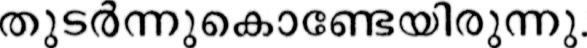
തുടര്‍ന്നുകൊണ്ടേയിരുന്നു.
